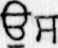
ਉਸ
